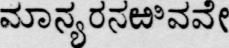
ಮಾನ್ಯರನಱಿವವೇ
